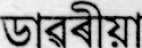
ডাৱৰীয়া
